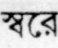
স্বরে
